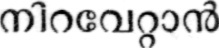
നിറവേറ്റാന്‍
